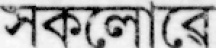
সকলোৱে
